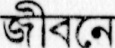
জীবনে
